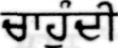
ਚਾਹੁੰਦੀ
